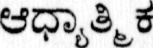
ಆಧ್ಯಾತ್ಮಿಕ
